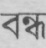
বন্ধ
